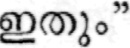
ഇതും”
